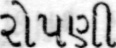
રોપણી
